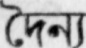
দৈন্য
